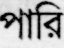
পারি
